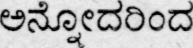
ಅನ್ನೋದರಿಂದ
